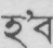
হ'ব
